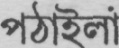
পঠাইলা
